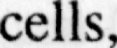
cells,
